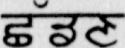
ਛੱਡਣ
